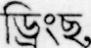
ড্ৰিংছ,
